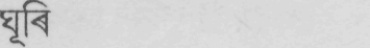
ঘূৰি
